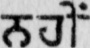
ਨਹੀਂ
